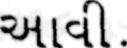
આવી.
